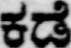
ಕಡೆ
